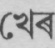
খেৰ
